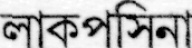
লাকপসিনা
